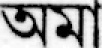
অমা
